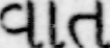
વાત
